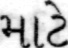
માટે
